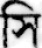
সি
